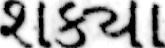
શક્યા
